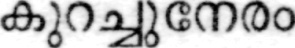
കുറച്ചുനേരം
